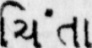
ચિંતા
